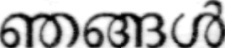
ഞങ്ങള്‍
